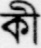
কী
